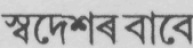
স্বদেশৰবাবে
